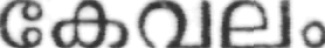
കേവലം
